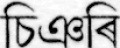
চিঞৰি
